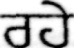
ਰਹੇ
